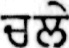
ਚਲੇ
